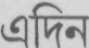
এদিন
